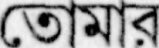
তোমার
